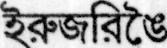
ইরুজরিঙৈ
